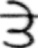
ਤੇ
